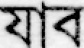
যাব
